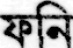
ফনি
